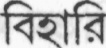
বিহারি
